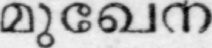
മുഖേന
